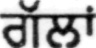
ਗੱਲਾਂ
